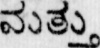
ಮತ್ತು
